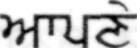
ਆਪਣੇ
